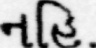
નહિ.
